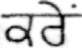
ਕਰੇਂ
